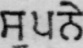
ਸੁਪਨੇ
